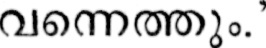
വന്നെത്തും.’
